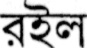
রইল
